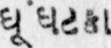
ઘૂંઘટકા
